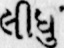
લીધું
